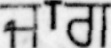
ਜਾਗ
